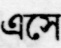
এসে
